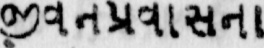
જીવનપ્રવાસના
